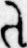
તે
